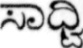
ಸಾಧ್ವಿ
